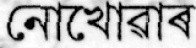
নোখোৱাৰ
